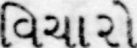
વિચારો
